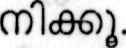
നിക്കൂ.
